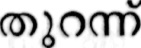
തുറന്ന്
